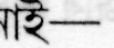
নাই-
